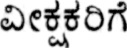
ವೀಕ್ಷಕರಿಗೆ
